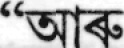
"আৰু
